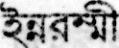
ইন্নরম্মী
